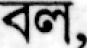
বল,
